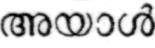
അയാള്‍
